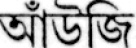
আঁউজি
